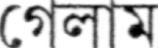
গেলাম
